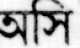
অসি
